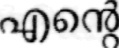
എന്റെ
